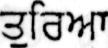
ਤੁਰਿਆ
